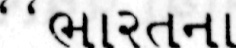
"ભારતના
